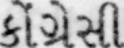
કોંગ્રેસી
